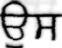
ਉਸ
